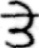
ਤੇ
